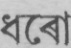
ধৰো
